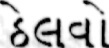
ઠેલવો
